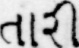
તારી
